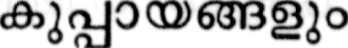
കുപ്പായങ്ങളും
